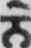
ਨੇ
